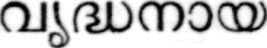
വൃദ്ധനായ
